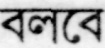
বলবে
